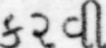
કરવી
